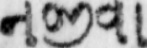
નજીવા
